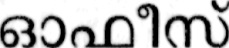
ഓഫീസ്
